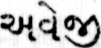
અવેજી
